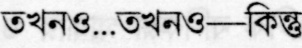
তখনও..তখনও–কিন্তু
